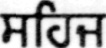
ਸਹਿਜ
